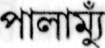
পালাম্যুঁ
